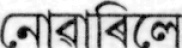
নোৱাৰিলে
